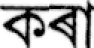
কৰা
